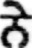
ਨੇ
